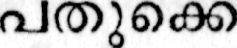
പതുക്കെ
